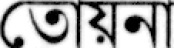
তোয়না
